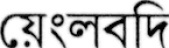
য়েংলবদি
